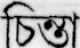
চিন্তা
